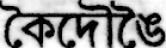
কৈদৌঙৈ
